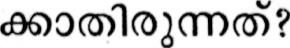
ക്കാതിരുന്നത്?
